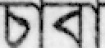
চাবা
